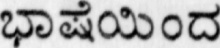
ಭಾಷೆಯಿಂದ
